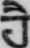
ਹੈ
